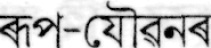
ৰূপ-যৌৱনৰ
